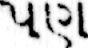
પણ
